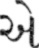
એ
